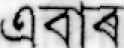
এবাৰ
